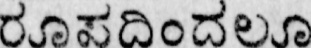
ರೂಪದಿಂದಲೂ
